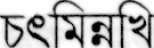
চৎমিন্নখি
